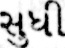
સુધી
